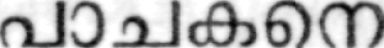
പാചകനെ
